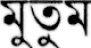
মুতুম
